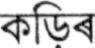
কড়িৰ
